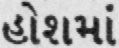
હોશમાં
